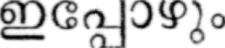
ഇപ്പോഴും
